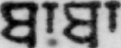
ਬਾਬਾ
